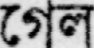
গেল
